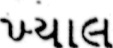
ખ્યાલ
